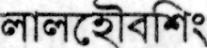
লালহৌবশিং
